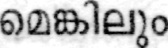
മെങ്കിലും
